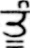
ਤੂੰ
